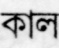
কাল
